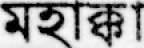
মহাক্কা
